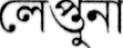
লেপ্তুনা
